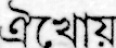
ঐখোয়
